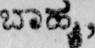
ಬಾಹ್ಯ,
